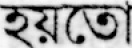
হয়তো
